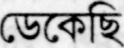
ডেকেছি
